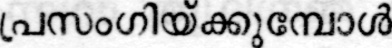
പ്രസംഗിയ്ക്കുമ്പോള്‍
